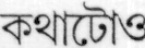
কথাটোও
